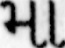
મા
